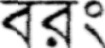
বরং
